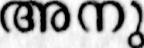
അനു
